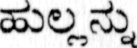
ಹುಲ್ಲನ್ನು
